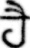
ਹੈ
